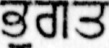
ਭੁਗਤ
